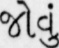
જોવું
